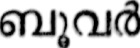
ബൂവര്‍
